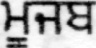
ਮੂਜਬ
